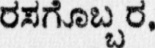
ರಸಗೊಬ್ಬರ,
